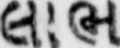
લાભ
